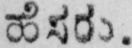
ಹೆಸರು.
